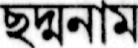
ছদ্মনাম
